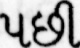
પછી
